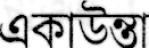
একাউন্তা
